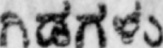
ಗಿಡಗಳು
